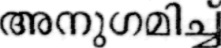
അനുഗമിച്ച്
